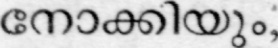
നോക്കിയും,
